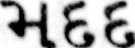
મદદ
